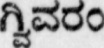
ಗ್ವಿವರಂ
